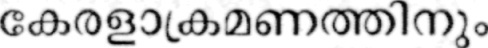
കേരളാക്രമണത്തിനും
